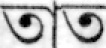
তাত
